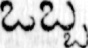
ಒಬ್ಬ
